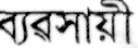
ব্যৱসায়ী
